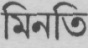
মিনতি
